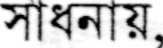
সাধনায়,
